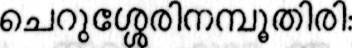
ചെറുശ്ശേരിനമ്പൂതിരി:
